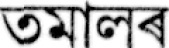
তমালৰ
